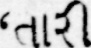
'તારી
